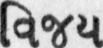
વિજય
